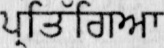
ਪ੍ਰਤਿੱਗਿਆ
